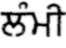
ਲੰਮੀ
